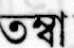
তম্বা
